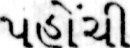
પહોંચી
